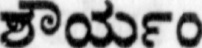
ಶೌರ್ಯಂ
